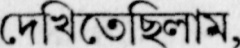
দেখিতেছিলাম,
